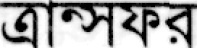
ত্রান্সফর
